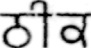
ਠੀਕ
